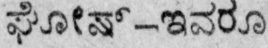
ಘೋಷ್-ಇವರೂ
